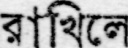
রাখিলে
